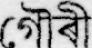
গৌৰী
